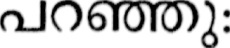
പറഞ്ഞു:
